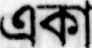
একা
